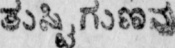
ತುಷ್ಟಿಗುಣವು
